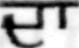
ਦਾ
